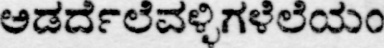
ಅಡರ್ದೆಲೆವಳ್ಳಿಗಳೆಲೆಯಂ
